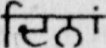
ਦਿਨਾਂ
